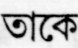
তাকে
